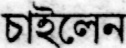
চাইলেন
